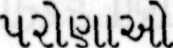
પરોણાઓ
